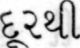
દૂરથી
